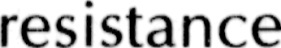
resistance
